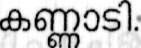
കണ്ണാടി.
